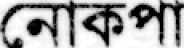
নোকপা
